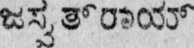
ಜಸ್ವತ್ರಾಯ್
